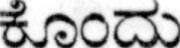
ಕೊಂದು
